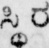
ಸ್ಥಿರ
